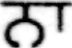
ਨਾ
